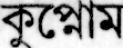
কুপ্নোম
